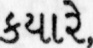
કયારે,
